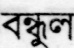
বন্ধুল
